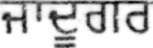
ਜਾਦੂਗਰ
